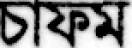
চাফম
